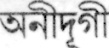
অনীদূগী
